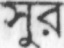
সুর
